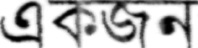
একজন
